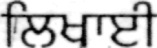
ਲਿਖਾਈ
